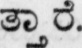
ತ್ತಾರೆ.
